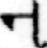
ન
